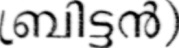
ബ്രിട്ടന്‍)
